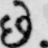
છે.
